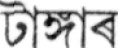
টাঙ্গাৰ
